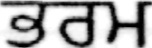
ਭਰਮ
